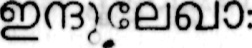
ഇന്ദുലേഖാ:
